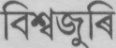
বিশ্বজুৰি
